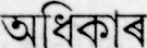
অধিকাৰ
